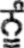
ਨੂੰ
